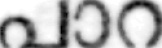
പാറ
